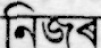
নিজৰ
